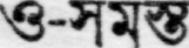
ও-সমস্ত
